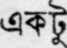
একটু
